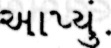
આપ્યું.
